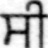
ਸੀ
